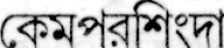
কেমপরশিংদা
